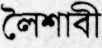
লৈশাবী
